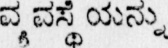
ವ್ಯವಸ್ಥೆಯನ್ನು
